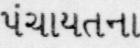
પંચાયતના
